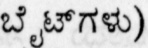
ಬೈಟ್ಗಳು)
